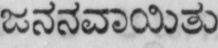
ಜನನವಾಯಿತು
